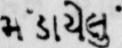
મંડાયેલું
